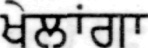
ਖੇਲਾਂਗਾ
